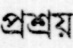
প্রশ্রয়
